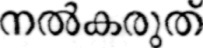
നല്‍കരുത്
